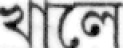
খালে
